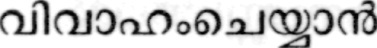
വിവാഹംചെയ്യാന്‍
